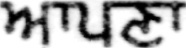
ਆਪਣਾ
